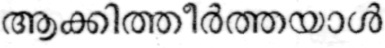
ആക്കിത്തീര്‍ത്തയാള്‍
